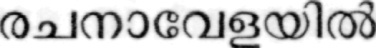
രചനാവേളയില്‍
